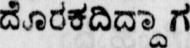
ದೊರಕದಿದ್ದಾಗ
